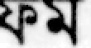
ফম
